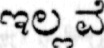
ಇಲ್ಲವೆ
